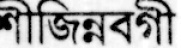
শীজিন্নবগী
